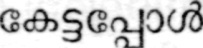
കേട്ടപ്പോള്‍
